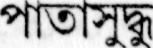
পাতাসুদ্ধু
